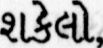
શકેલો,
